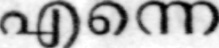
എന്നെ
